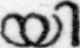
യി
